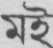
মই
